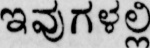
ಇವುಗಳಲ್ಲಿ
